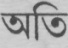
অতি
